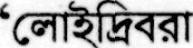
‘লোইদ্রিবরা
